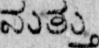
ಮತ್ತು
